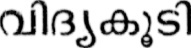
വിദ്യകൂടി
